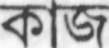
কাজ
